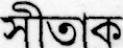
সীতাক
